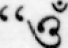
"ওঁ
